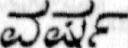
ವರ್ಷ
